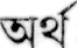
অর্থ
